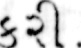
કરી.
